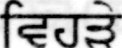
ਵਿਹੜੇ
